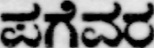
ಪಗೆವರ
